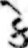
કે
